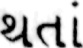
થતાં
